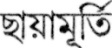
ছায়ামূর্তি
